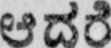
ಆದರೆ
